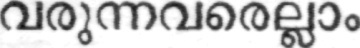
വരുന്നവരെല്ലാം
